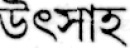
উৎসাহ
